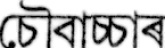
চৌবাচ্চাৰ
